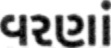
વરણાં
